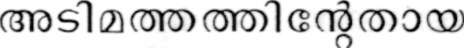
അടിമത്തത്തിന്റേതായ
